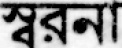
স্বরনা
